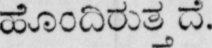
ಹೊಂದಿರುತ್ತದೆ.
